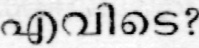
എവിടെ?
